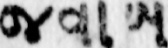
જવાબ
